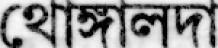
থোঙ্গালদা
